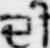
ਦੀ
